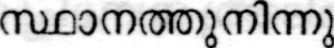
സ്ഥാനത്തുനിന്നു
